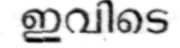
ഇവിടെ
